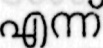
എന്ന്
